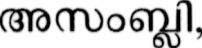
അസംബ്ലി,
